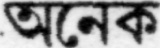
অনেক
